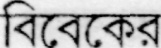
বিবেকের
